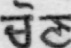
ਚੋਣ
